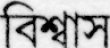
বিশ্বাস
